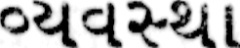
વ્યવસ્થા
